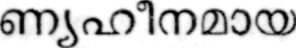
ണ്യഹീനമായ
